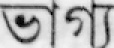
ভাগ্য
